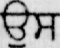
ਉਸ
